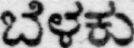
ಬೆಳಕು
